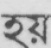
হয়
